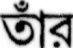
তাঁর
